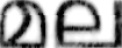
മല
